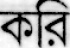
করি
